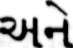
અને
